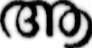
ആ
